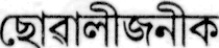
ছোৱালীজনীক
